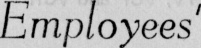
Employees’
